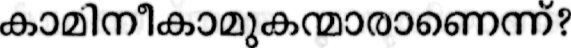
കാമിനീകാമുകന്മാരാണെന്ന്?
